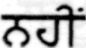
ਨਹੀਂ
